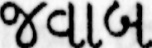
જવાબ
